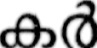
കര്‍
